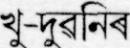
খু-দুৱনিৰ
